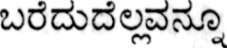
ಬರೆದುದೆಲ್ಲವನ್ನೂ
